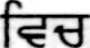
ਵਿਚ
